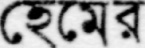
হেমের
